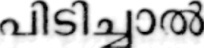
പിടിച്ചാല്‍
